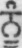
ਨੂੰ
